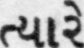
ત્યારે
